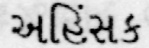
અહિંસક
